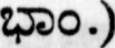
ಭಾಂ.)
